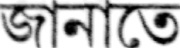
জানাতে
